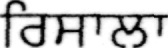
ਰਿਸਾਲਾ
